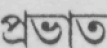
প্ৰভাত
